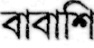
বাবাশি
